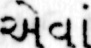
એવાં
